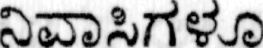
ನಿವಾಸಿಗಳೂ
